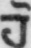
ਹੋ
